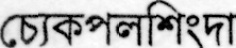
চ্যেকপলশিংদা
